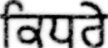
ਕਿਧਰੇ
